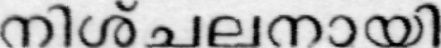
നിശ്ചലനായി
